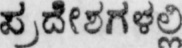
ಪ್ರದೇಶಗಳಲ್ಲಿ
